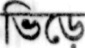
ভিড়ে
